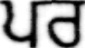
ਪਰ
